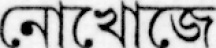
নোখোজে
